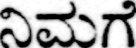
ನಿಮಗೆ
